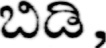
ಬಿಡಿ,
